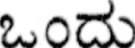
ಒಂದು
